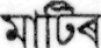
মাটিৰ
